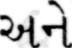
અને
